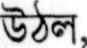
উঠল,
